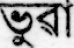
ভুৱা
